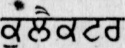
ਕੁਲੈਕਟਰ
